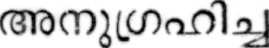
അനുഗ്രഹിച്ച
